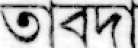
তাবদা
